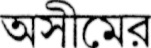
অসীমের
